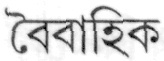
বৈবাহিক
